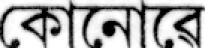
কোনোৱে
